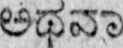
ಅಥವಾ
